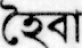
হৈবা
